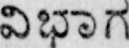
ವಿಭಾಗ
